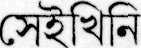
সেইখিনি
